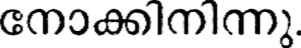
നോക്കിനിന്നു.
